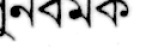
পুনবমক
